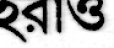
হরাও
